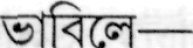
ভাবিলে-
